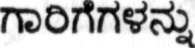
ಗಾರಿಗೆಗಳನ್ನು
